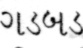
ગડબડ
